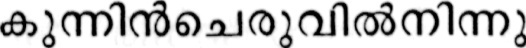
കുന്നിന്‍ചെരുവില്‍നിന്നു
